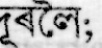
দূৰলৈ;
